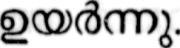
ഉയര്‍ന്നു.
